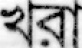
খরা
